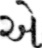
એ
